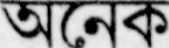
অনেক
